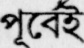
পূর্বেই
